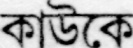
কাউকে
